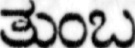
ತುಂಬ
